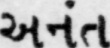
અનંત
